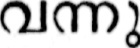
വന്നു
